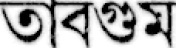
তাবগুম
